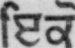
ਇਕੋ
